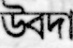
উবদা
